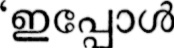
‘ഇപ്പോള്‍
